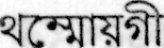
থম্মোয়গী
